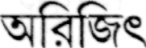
অরিজিৎ
